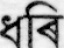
ধৰি
